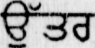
ਉੱਤਰ
